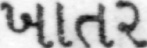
ખાતર
